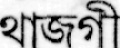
থাজগী
